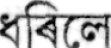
ধৰিলে
